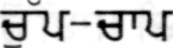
ਚੁੱਪ-ਚਾਪ
